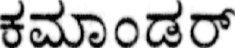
ಕಮಾಂಡರ್
